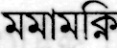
মমামক্নি
